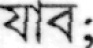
যাব;
